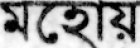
মহোয়
